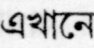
এখানে
